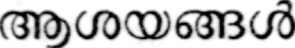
ആശയങ്ങള്‍
